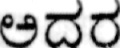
ಅದರ
